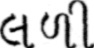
લળી
